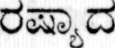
ರಷ್ಯಾದ
